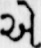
એ
